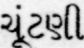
ચૂંટણી
